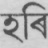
হৰি
